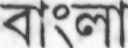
বাংলা
